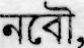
নবৌ,
